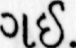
ગઈ.
